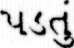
પડતું
